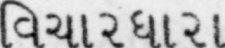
વિચારધારા
